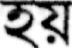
হয়
